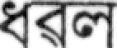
ধৱল
